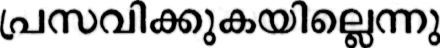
പ്രസവിക്കുകയില്ലെന്നു
